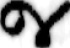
જ
